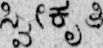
ಸ್ವೀಕೃತಿ
